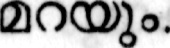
മറയും.
